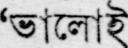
‘ভালোই
